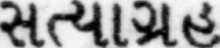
સત્યાગ્રહ
